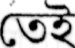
তেই
